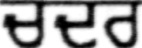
ਚਦਰ
